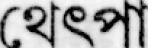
থেৎপা
